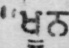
''ਖੂਨ
